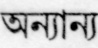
অন্যান্য
